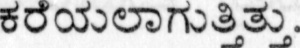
ಕರೆಯಲಾಗುತ್ತಿತ್ತು.
